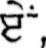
ਏਂ,
